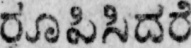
ರೂಪಿಸಿದರೆ
